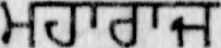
ਮਹਾਰਾਜ
